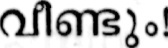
വീണ്ടും!
